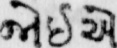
જોઈએ
